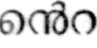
ന്റെ
